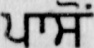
ਪਾਸੋਂ
